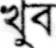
খুব
